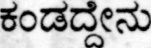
ಕಂಡದ್ದೇನು
